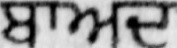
ਬਾਅਦ
